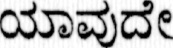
ಯಾವುದೇ
